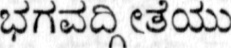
ಭಗವದ್ಗೀತೆಯು
